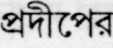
প্রদীপের
